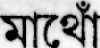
মাথোঁ
